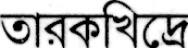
তারকখিদ্রে
